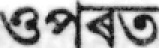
ওপৰত
